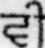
ਵੀ
